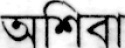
অশিবা
